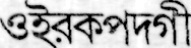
ওইরকপদগী
